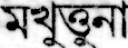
মখুত্তুনা
